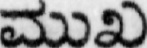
ಮುಖ
